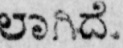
ಲಾಗಿದೆ.
